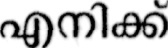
എനിക്ക്
